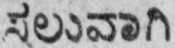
ಸಲುವಾಗಿ
